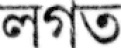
লগত
